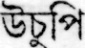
উচুপি
